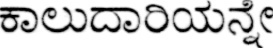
ಕಾಲುದಾರಿಯನ್ನೇ
